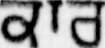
ਕਾਰ
